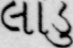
લાડુ
